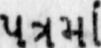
પત્રમાં
